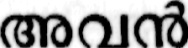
അവന്‍
